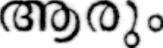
ആരും
